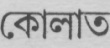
কোলাত
